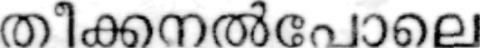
തീക്കനല്‍പോലെ
